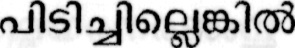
പിടിച്ചില്ലെങ്കില്‍
